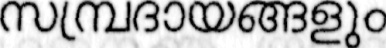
സമ്പ്രദായങ്ങളും
